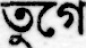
তুগে
